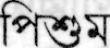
পিশুম
